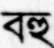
বহু
